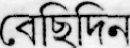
বেছিদিন
